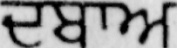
ਦਬਾਅ
